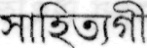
সাহিত্যগী
